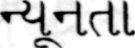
ન્યૂનતા
